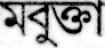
মবুক্তা
